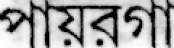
পায়রগা
